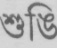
শুঙি
